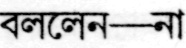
বললেন–না
